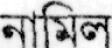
নামিল
